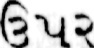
ઉપર
